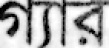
গ্যার
